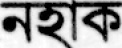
নহাক
